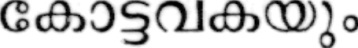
കോട്ടവകയും
